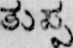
ತುಪ್ಪ
